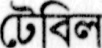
টেবিল
